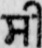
ਸੀ
